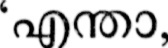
'എന്താ,
